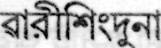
ৱারীশিংদুনা
